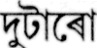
দুটাৰো
